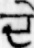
ਦੇ
